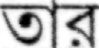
তার
